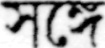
সঙ্গে
